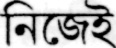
নিজেই
